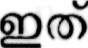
ഇത്
